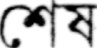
শেষ
